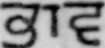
ਭਾਵ
